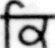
ਕਿ
